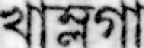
খাম্লগা
